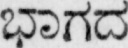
ಭಾಗದ
